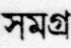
সমগ্র
